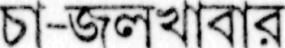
চা-জলখাবার
